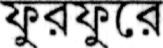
ফুরফুরে
